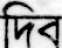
দিব
